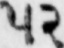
પર
